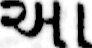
આ
